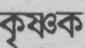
কৃষ্ণক
